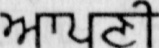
ਆਪਣੀ
